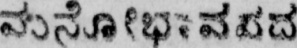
ಮನೋಭಾವಪದ
